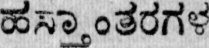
ಹಸ್ತಾಂತರಗಳ
